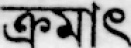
ক্রমাৎ
